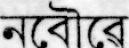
নবৌৱে
